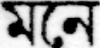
মনে
